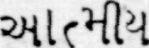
આત્મીય
